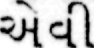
એવી
